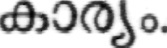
കാര്യം.
